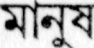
মানুষ
